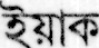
ইয়াক
